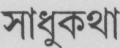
সাধুকথা
